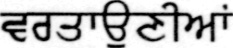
ਵਰਤਾਉਣੀਆਂ
